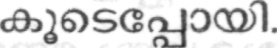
കൂടെപ്പോയി.
